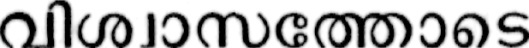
വിശ്വാസത്തോടെ
